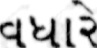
વધારે
